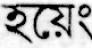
হয়েং
